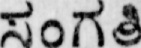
ಸಂಗತಿ
